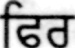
ਫਿਰ
